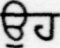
ਉਹ
